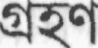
গ্রহণ
